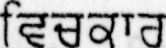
ਵਿਚਕਾਰ
